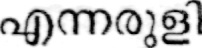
എന്നരുളി
